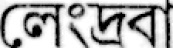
লেংদ্রবা
